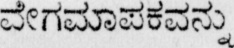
ವೇಗಮಾಪಕವನ್ನು
